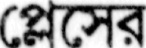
প্লেসের
